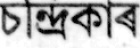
চন্দ্ৰিকাৰ
